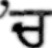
'ਚ
